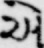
એ
